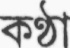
কণ্ঠা
